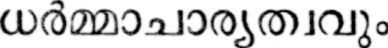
ധര്‍മ്മാചാര്യത്വവും
